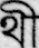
থী
